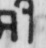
ਸੀ
